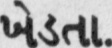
ખેડતા.
